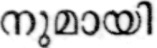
നുമായി
